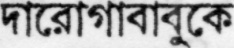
দারোগাবাবুকে
